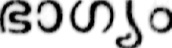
ഭാഗ്യം
